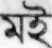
মই
